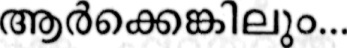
ആര്‍ക്കെങ്കിലും...
